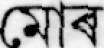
মোৰ
